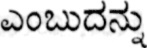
ಎಂಬುದನ್ನು
